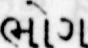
ભોગ
